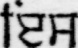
ਇਸ
